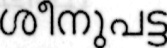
ശീനുപട്ട
